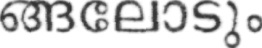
ങ്ങലോടും
